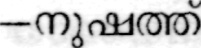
-നുഷത്ത്
